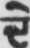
ਦੇ
